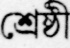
শ্রেষ্ঠী
